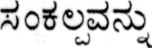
ಸಂಕಲ್ಪವನ್ನು
